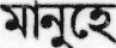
মানুহে
